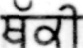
ਥੱਕੀ
